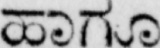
ಹಾಗೂ
